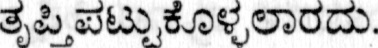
ತೃಪ್ತಿಪಟ್ಟುಕೊಳ್ಳಲಾರದು.
